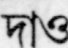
দাও
